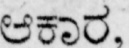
ಆಕಾರ,
